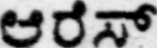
ಆರೆಸ್
